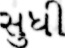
સુધી
